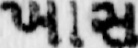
ખાસ
